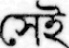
সেই
